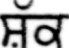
ਸ਼ੱਕ
